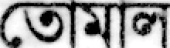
তোমাল
